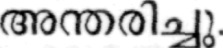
അന്തരിച്ചു.
